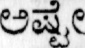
ಅಷ್ಟೇ
